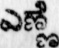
ಎಣ್ಣೆ
